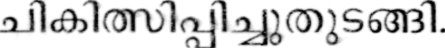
ചികിത്സിപ്പിച്ചുതുടങ്ങി.
